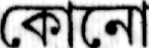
কোনো
